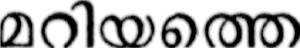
മറിയത്തെ
